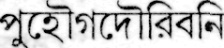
পুহৌগদৌরিবনি
